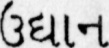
ઉદ્યાન
